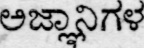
ಅಜ್ಞಾನಿಗಳ
